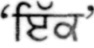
'ਇੱਕ'
